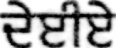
ਦੇਈਏ
